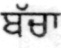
ਬੱਚਾ
